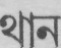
থান
